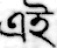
এই
